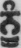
ਨੂੰ
